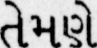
તેમણે
